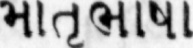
માતૃભાષા
